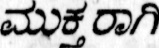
ಮುಕ್ತರಾಗಿ
